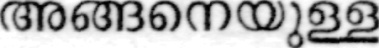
അങ്ങനെയുള്ള
